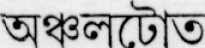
অঞ্চলটোত
